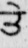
ਤੇ
